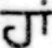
ਹਾਂ
